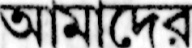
আমাদের
